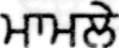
ਮਾਮਲੇ
